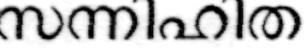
സന്നിഹിത
